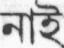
নাই
